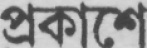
প্ৰকাশে
